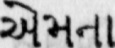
એમના
